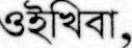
ওইখিবা,
